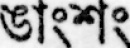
ঙাংশং
